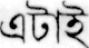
এটাই
